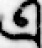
এ
